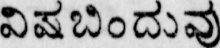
ವಿಷಬಿಂದುವು
